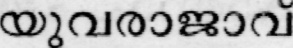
യുവരാജാവ്
